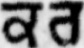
ਕਰ
